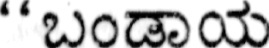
"ಬಂಡಾಯ
